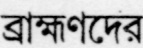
ব্রাহ্মণদের
